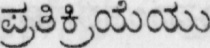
ಪ್ರತಿಕ್ರಿಯೆಯು
